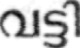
വട്ടി
